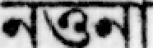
নত্তনা
